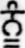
ਨੂੰ
